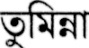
তুমিন্না
